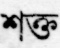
শক্ত
